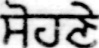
ਸੋਹਣੇ
